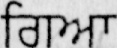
ਗਿਆ
